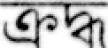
ক্রদ্ধ
